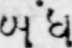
બંધ
